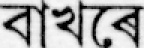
বাখৰে
